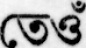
তেওঁ
